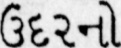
ઉંદરનો
